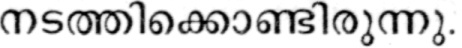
നടത്തിക്കൊണ്ടിരുന്നു.
